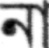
না
